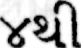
૪થી
